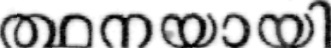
ത്ഥനയായി
